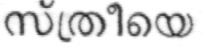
സ്ത്രീയെ
